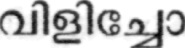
വിളിച്ചോ
